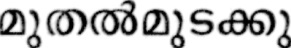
മുതല്‍മുടക്കു
